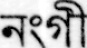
নংগী
